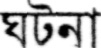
ঘটনা
